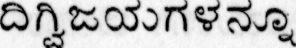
ದಿಗ್ವಿಜಯಗಳನ್ನೂ
